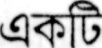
একটি
